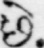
છે.
